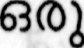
ഒരു
